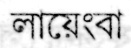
লায়েংবা
